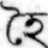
হৈ
